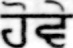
ਹੋਵੇ
